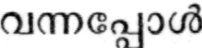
വന്നപ്പോള്‍
